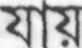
যায়
